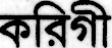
করিগী
